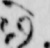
છે.
